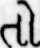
તો
